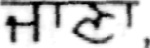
ਜਾਣਾ,
